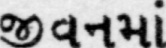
જીવનમાં
